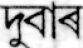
দুবাৰ
